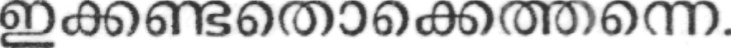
ഇക്കണ്ടതൊക്കെത്തന്നെ
